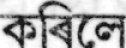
কৰিলে
